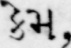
કેમ,
